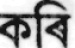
কৰি
